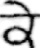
ਕੇ
